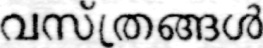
വസ്ത്രങ്ങള്‍
